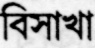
বিসাখা
